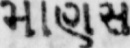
માણસ
